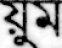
য়ুম
